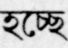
হচ্ছে
